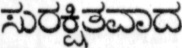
ಸುರಕ್ಷಿತವಾದ
